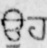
ਉਹ
